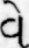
વે
